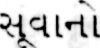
સૂવાનો
